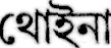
থোইনা
